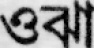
ওঝা
